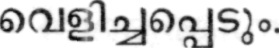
വെളിച്ചപ്പെടും.
